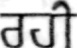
ਰਹੀ
